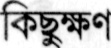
কিছুক্ষণ
